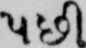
પછી
